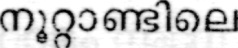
നൂറ്റാണ്ടിലെ
